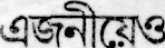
এজনীয়েও
